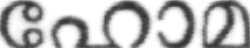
ഹോമ
